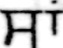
ਸਾਂ
